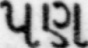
પણ
